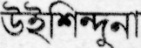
উইশিন্দুনা
